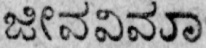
ಜೀವವಿಮಾ
